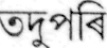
তদুপৰি
